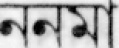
ননমা
